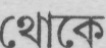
থোকে
